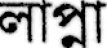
লাপ্না
